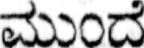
ಮುಂದೆ
